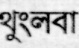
থুংলবা
